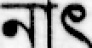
নাৎ
